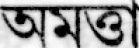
অমত্তা
